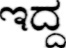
ಇದ್ದ
